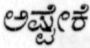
ಅಷ್ಟೇಕೆ
